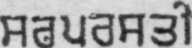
ਸਰਪਰਸਤੀ
